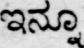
ಇನ್ನೂ
